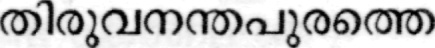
തിരുവനന്തപുരത്തെ
